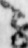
કે
